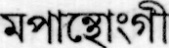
মপান্থোংগী
